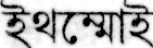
ইথম্মোই
